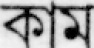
কাম
